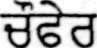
ਚੌਫੇਰ
